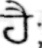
ਹੈ;
